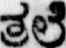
ತಲೆ
